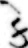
કે
